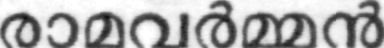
രാമവര്‍മ്മന്‍
